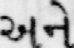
અને
